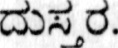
ದುಸ್ತರ.
